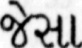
જેસા
